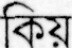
কিয়
